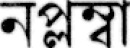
নপ্লম্বা
